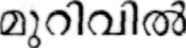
മുറിവില്‍
